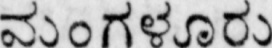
ಮಂಗಳೂರು
